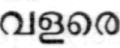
വളരെ
